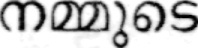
നമ്മുടെ
